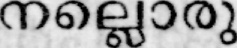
നല്ലൊരു
